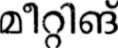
മീറ്റിങ്
